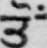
ਤੋਂ
